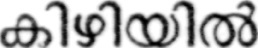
കിഴിയില്‍
